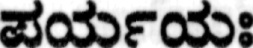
ಪರ್ಯಯಃ
